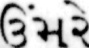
ઉંમરે
